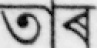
তাৰ
